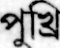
পুখ্রি
